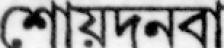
শোয়দনবা
